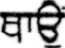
ਥਾਉਂ
